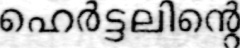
ഹെര്‍ട്ടലിന്റെ
